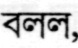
বলল,
